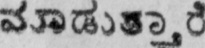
ಮಾಡುತ್ತಾರೆ
